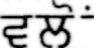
ਵਲੋਂ
